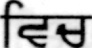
ਵਿਚ
